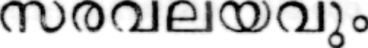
സരവലയവും
